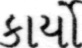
કાર્યો
